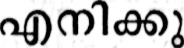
എനിക്കു
